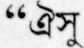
“ঐসু
